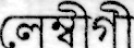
লেম্বীগী
